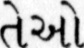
તેઓ
